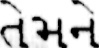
તેમને
